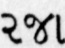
રજા
